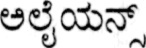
ಅಲೈಯನ್ಸ್
